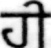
ਹੀ
